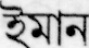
ইমান
